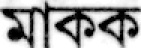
মাকক
